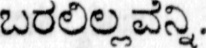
ಬರಲಿಲ್ಲವೆನ್ನಿ.
